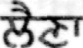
ਲੈਣਾ
